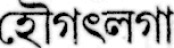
হৌগৎলগা
